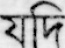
যদি
